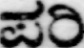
ಪರಿ
